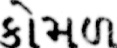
કોમળ
